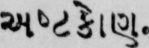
અષ્ટકોણ-
